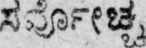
ಸರ್ವೋಚ್ಚ
